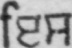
ਇਸ
